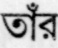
তাঁর
